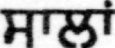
ਸਾਲਾਂ
